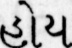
હોય
